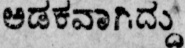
ಅಡಕವಾಗಿದ್ದು
